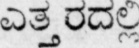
ಎತ್ತರದಲ್ಲಿ
